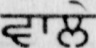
ਵਾਲੇ
